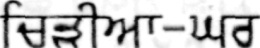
ਚਿੜੀਆ-ਘਰ
